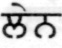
ਲੇਨ
